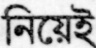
নিয়েই
